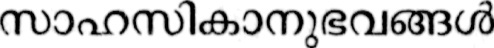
സാഹസികാനുഭവങ്ങള്‍
